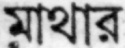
মাথার
